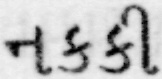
નક્કી
